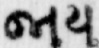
જાય
